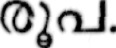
രൂപ.
